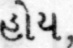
હોય,
